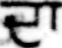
ਦਾ
